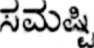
ಸಮಷ್ಟಿ
